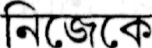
নিজেকে
